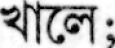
খালে;
